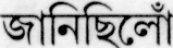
জানিছিলোঁ
